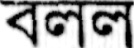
বলল
